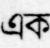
এক
